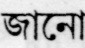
জানো
